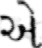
એ
